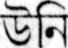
উনি
